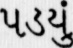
પડ્યું
